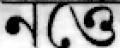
নত্তে
